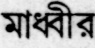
মাধ্বীর
